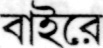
বাইরে
